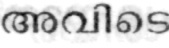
അവിടെ
